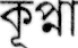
কূপ্না
